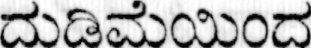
ದುಡಿಮೆಯಿಂದ
